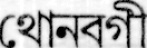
থোনবগী
